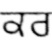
ਕਰ
